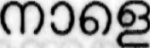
നാളെ
